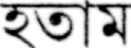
হতাম
